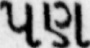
પણ
